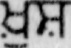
ਖ਼ੁਸ਼
